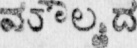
ಮೌಲ್ಯದ
